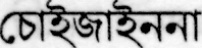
চোইজাইননা
